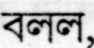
বলল,
